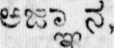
ಅಜ್ಞಾನ,
